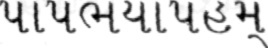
પાપભયાપહમ્
